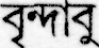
বৃন্দাবু
